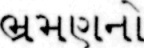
ભ્રમણનો
